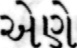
એણે
